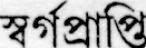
স্বর্গপ্রাপ্তি
